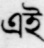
এই
